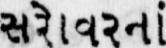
સરોવરનાં
